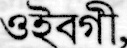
ওইবগী,
